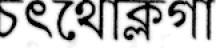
চৎথোক্লগা
